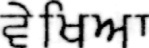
ਵੇਖਿਆ
